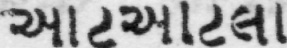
આટઆટલા
